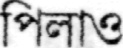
পিলাও
